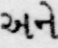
અને
